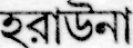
হরাউনা
